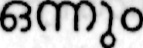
ഒന്നും
